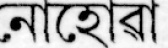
নোহোৱা
